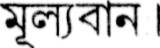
মূল্যবান।
